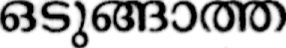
ഒടുങ്ങാത്ത
